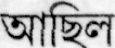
আছিল
